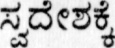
ಸ್ವದೇಶಕ್ಕೆ
